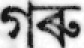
গৰু
